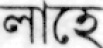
লাহে
